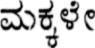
ಮಕ್ಕಳೇ
